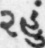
રહું
